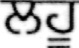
ਲਹੂ
